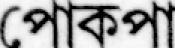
পোকপা
